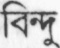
বিন্দু
